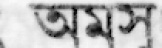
খরতনা
